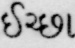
ઈચ્છા
